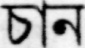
চান
